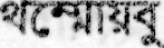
থম্মোয়বু
